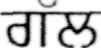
ਗੱਲ
